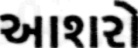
આશરો
